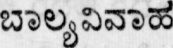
ಬಾಲ್ಯವಿವಾಹ
